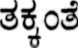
ತಕ್ಕಂತೆ
